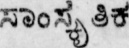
ಸಾಂಸ್ಕೃತಿಕ
